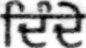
ਦਿੰਦੇ
